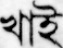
খাই
